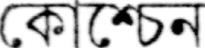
কোশ্চেন
